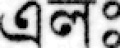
এলঃ
